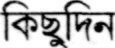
কিছুদিন
